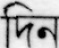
দিন
